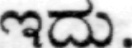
ಇದು.
